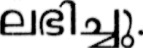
ലഭിച്ചു.
